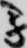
કે
